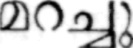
മറച്ചു
